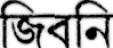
জিবনি
